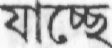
যাচ্ছে
